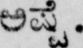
ಅಷ್ಟೆ.
